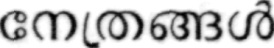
നേത്രങ്ങള്‍
